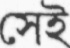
সেই
